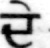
ਦੇ
